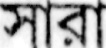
সারা
